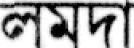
লমদা
